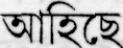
আহিছে
